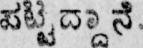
ಪಟ್ಟಿದ್ದಾನೆ.
